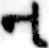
ન
